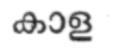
കാള
